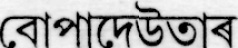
বোপাদেউতাৰ
